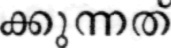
ക്കുന്നത്
